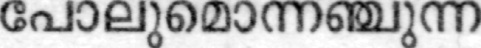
പോലുമൊന്നഞ്ചുന്ന
